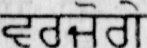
ਵਰਜੋਗੇ
